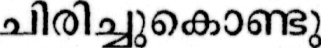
ചിരിച്ചുകൊണ്ടു
